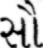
સૌ
